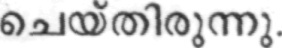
ചെയ്തിരുന്നു.
